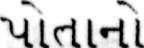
પોતાનો
